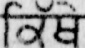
ਕਿੈੱਥੇ
